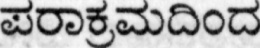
ಪರಾಕ್ರಮದಿಂದ
